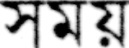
সময়
